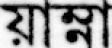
য়াম্না
